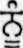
ਨੂੰ
